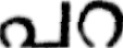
പറ
